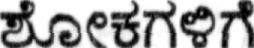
ಶೋಕಗಳಿಗೆ
